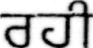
ਰਹੀ
